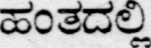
ಹಂತದಲ್ಲಿ
